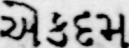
એકદમ
